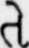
તે
